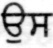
ਉਸ
